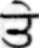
ਤੇ
